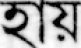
হায়া
